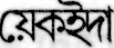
য়েকইদা
